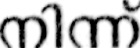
നിന്ന്
